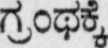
ಗ್ರಂಥಕ್ಕೆ
